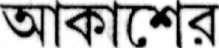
আকাশের
